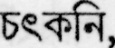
চৎকনি,
